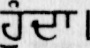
ਹੁੰਦਾ।
